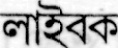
লাইবক
